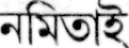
নমিতাই
